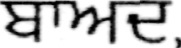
ਬਾਅਦ,
